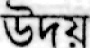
উদয়
